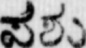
ಪಶು
